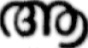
ആ
